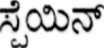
ಸ್ಪೆಯಿನ್
